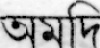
অমদি
